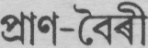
প্ৰাণ-বৈৰী
